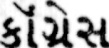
કૉંગ્રેસ
